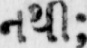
નથી;
